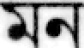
মন
